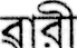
ৱারী
